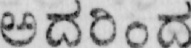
ಅದರಿಂದ
